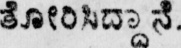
ತೋರಿಸಿದ್ದಾನೆ.
